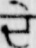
ਦੇ
